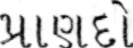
પ્રાણદો
